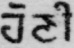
ਹੋਣੀ
